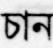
চান
